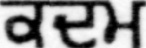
ਕਦਮ
